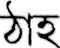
ঠাহ
